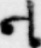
ન
